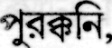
পুরক্কনি,
